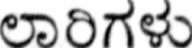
ಲಾರಿಗಳು
